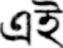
এই
